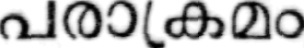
പരാക്രമം
